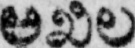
ಅಖಿಲ
